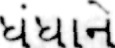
ધંંધાને
